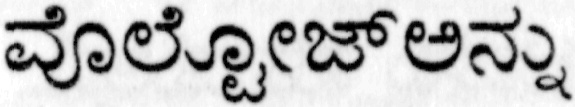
ವೋಲ್ಟೋಜ್‌ಅನ್ನು
